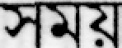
সময়
